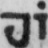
ਹਾਂ
